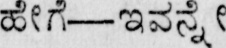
ಹೇಗೆ-ಇವನ್ನೇ
